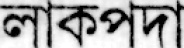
লাকপদা
